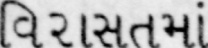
વિરાસતમાં
